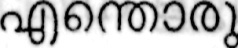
എന്തൊരു
